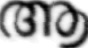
ആ
